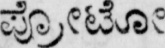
ಪ್ರೋಟೋ
